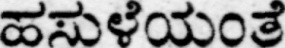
ಹಸುಳೆಯಂತೆ
